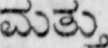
ಮತ್ತು
